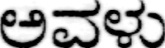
ಅವಳು
